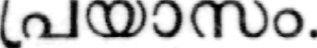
പ്രയാസം.
